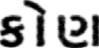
કોણ
